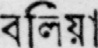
বলিয়া
